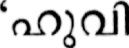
'ഹുവി
